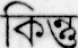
কিন্তু
